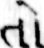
તો
